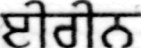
ਈਰੀਨ
